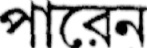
পারেন
